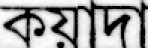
কয়াদা
